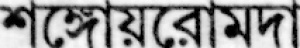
শঙ্গোয়রোমদা
